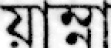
য়াম্না
